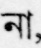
না,
